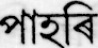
পাহৰি
